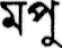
মপু
